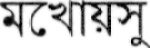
মখোয়সু
